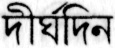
দীর্ঘদিন
